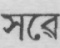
সৱে
